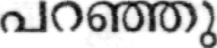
പറഞ്ഞു
